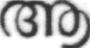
ആ
